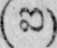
(ಐ)
